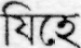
যিহে
